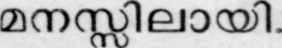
മനസ്സിലായി.
